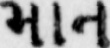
માન
